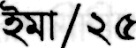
ইমা/২৫
